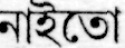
নাইতো
